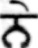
ਨੇ
